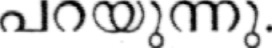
പറയുന്നു.
